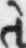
તે
